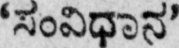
‘ಸಂವಿಧಾನ’
